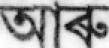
আৰু
